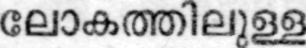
ലോകത്തിലുള്ള
